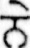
ਨੇ
